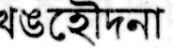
খঙহৌদনা
